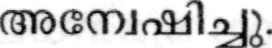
അന്വേഷിച്ചു.
